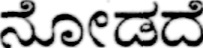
ನೋಡದೆ
